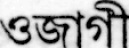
ওজাগী
